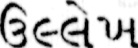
ઉલ્લેખ
